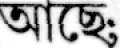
আছে;
